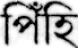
পিঁহি
